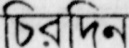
চিরদিন
